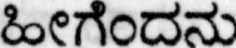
ಹೀಗೆಂದನು
